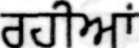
ਰਹੀਆਂ
